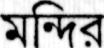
মন্দির
